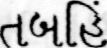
તબહિં
